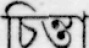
চিন্তা
